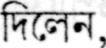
দিলেন,
